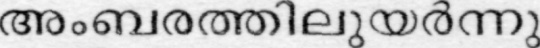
അംബരത്തിലുയര്‍ന്നു
